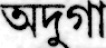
অদুগা
